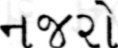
નજરો
